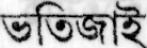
ভতিজাই
